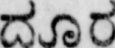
ದೂರ
